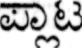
ಪ್ಲಾಟ
